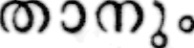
താനും
